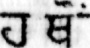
ਹਥੋਂ
